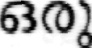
ഒരു
